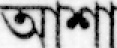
আশা
